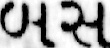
બસ
